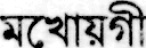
মখোয়গী
